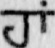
ਹਾਂ
